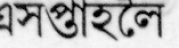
এসপ্তাহলৈ
